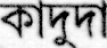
কাদুদা
